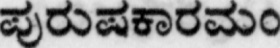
ಪುರುಷಕಾರಮಂ
